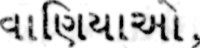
વાણિયાઓ,
